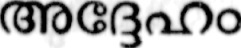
അദ്ദേഹം
